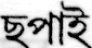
ছপাই
